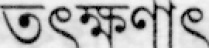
তৎক্ষণাৎ
